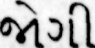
જોગી
